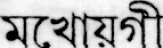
মখোয়গী
